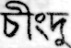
চীংদু
